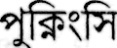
পুক্নিংসি
